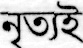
নৃত্যই
